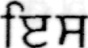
ਇਸ
